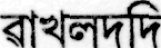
ৱাখলদদি
